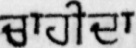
ਚਾਹੀਦਾ
